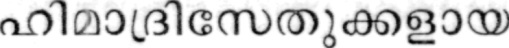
ഹിമാദ്രിസേതുക്കളായ
